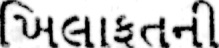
ખિલાફતની
